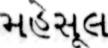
મહેસૂલ
